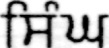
ਸਿੰਘ
